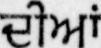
ਦੀਆਂ
